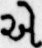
એ
